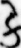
કે
